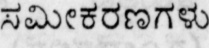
ಸಮೀಕರಣಗಳು
